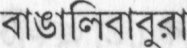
বাঙালিবাবুরা
